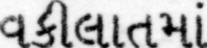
વકીલાતમાં
